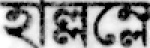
হাল্লম্লে
